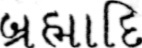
બ્રહ્માદિ
